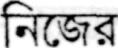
নিজের
